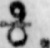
ಕಿ.
